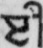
ਈ
